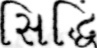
સિદ્ધિં
